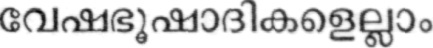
വേഷഭൂഷാദികളെല്ലാം
